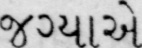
જગ્યાએ
